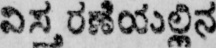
ವಿಸ್ತರಣೆಯಲ್ಲಿನ
